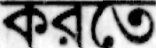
করতে
